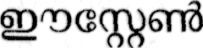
ഈസ്റ്റേണ്‍
